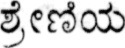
ಶ್ರೇಣಿಯ
